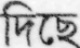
দিছে
